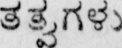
ತತ್ವಗಳು
